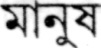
মানুষ
